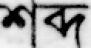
শব্দ
